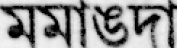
মমাঙদা
